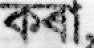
কৰা,
